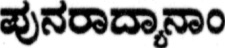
ಪುನರಾದ್ಯಾನಾ೦
